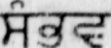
ਸੰਭਵ
